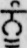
ਨੂੰ
